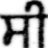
ਸੀ
